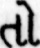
તો
